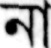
না
